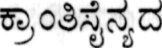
ಕ್ರಾಂತಿಸೈನ್ಯದ
